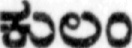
ಕುಲಂ
